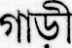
গাড়ী
